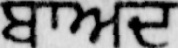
ਬਾਅਦ
